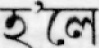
হ'লে
